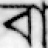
বা
